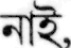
নাই,
